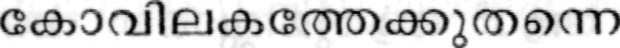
കോവിലകത്തേക്കുതന്നെ
